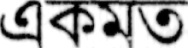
একমত
